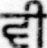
ਵੀ
